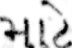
માટે
